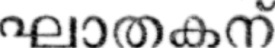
ഘാതകന്
